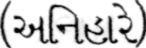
(અનિહારે)
